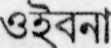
ওইবনা
